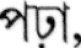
পঢ়া,
